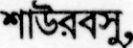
শাউরবসু,
